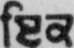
ਇਕ
